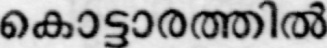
കൊട്ടാരത്തില്‍
